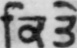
ਕਿਤੇ
